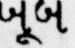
ખૂબ
